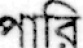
পারি
